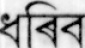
ধৰিব
